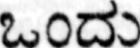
ಒಂದು
